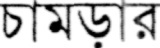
চামড়ার
